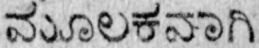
ಮೂಲಕವಾಗಿ
